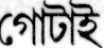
গোটাই
